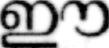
ഈ
